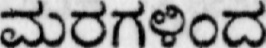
ಮರಗಳಿಂದ
